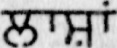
ਲਾਸ਼ਾਂ
